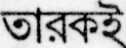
তারকই
